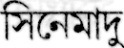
সিনেমাদু
